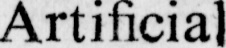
Artificial
